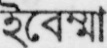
ইবেম্মা
